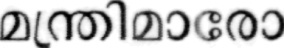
മന്ത്രിമാരോ
